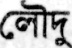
লৌদু
